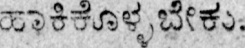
ಹಾಕಿಕೊಳ್ಳಬೇಕು.
